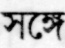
সঙ্গে
